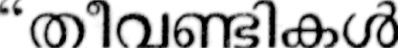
"തീവണ്ടികള്‍
